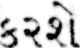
કરશે
